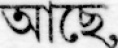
আছে,
